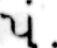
પં.
